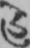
હે
